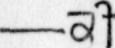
----ਕੀ
